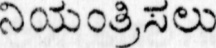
ನಿಯಂತ್ರಿಸಲು
